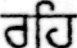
ਰਹਿ
